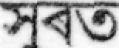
সুৰত
